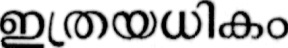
ഇത്രയധികം
